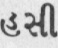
હસી
